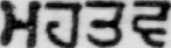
ਮਹਤਵ
